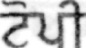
ਟੋਪੀ
